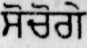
ਸੋਚੋਗੇ
